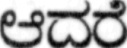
ಆದರೆ
